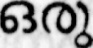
ഒരു
